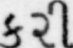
કરી
